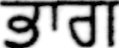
ਭਾਗ
